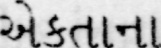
એકતાના
